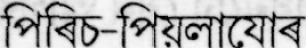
পিৰিচ-পিয়লাযোৰ
